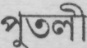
পুতলী
